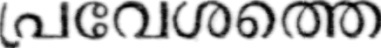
പ്രവേശത്തെ
